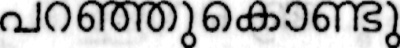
പറഞ്ഞുകൊണ്ടു
